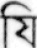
যি
